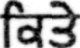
ਕਿਤੇ
